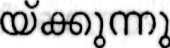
യ്ക്കുന്നു
